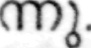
ന്നു.
